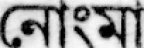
নোংমা
